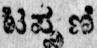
ಟಿಪ್ಪಣಿ
